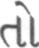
તો
